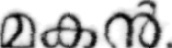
മകന്‍.
